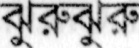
ঝুরুঝুরু
